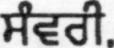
ਸੰਵਰੀ,
